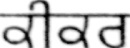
ਕੀਕਰ
